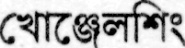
খোঞ্জেলশিং
